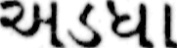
અડધા
